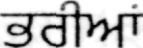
ਭਰੀਆਂ
